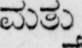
ಮತ್ತು
